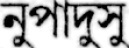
নুপাদুসু
